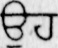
ਉਹ
